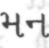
મન
